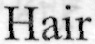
Hair
